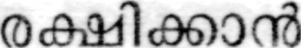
രക്ഷിക്കാന്‍
